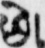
છો
